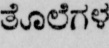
ತೊಲೆಗಳ
